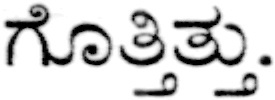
ಗೊತ್ತಿತ್ತು.
